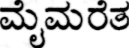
ಮೈಮರೆತ
